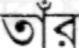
তাঁর
